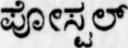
ಪೋಸ್ಟಲ್
